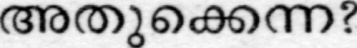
അതുക്കെന്ന?
